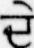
ਦੇ
